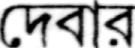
দেবার
